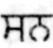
ਸਨ
